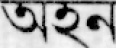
অহন
